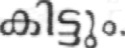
കിട്ടും.
